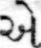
એ
